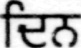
ਦਿਨ
